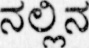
ನಲ್ಲಿನ
